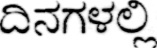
ದಿನಗಳಲ್ಲಿ
